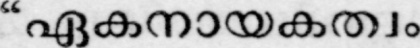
"ഏകനായകത്വം
